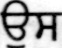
ਉਸ
